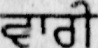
ਵਾਰੀ
